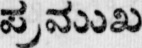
ಪ್ರಮುಖ
